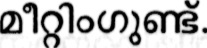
മീറ്റിംഗുണ്ട്.
